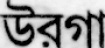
উরগা
